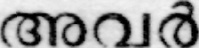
അവര്‍
